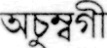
অচুম্বগী
